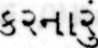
કરનારું
